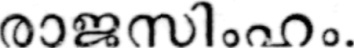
രാജസിംഹം.
